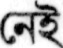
নেই
